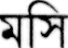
মসি
